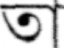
তা
